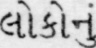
લોકોનું
